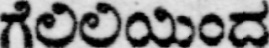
ಗೆಲಿಲಿಯಿಂದ
